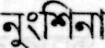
নুংশিনা
